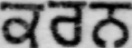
ਕਰਨ
